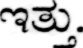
ಇತ್ತು.
